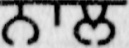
ਨਾਲ
